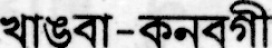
খাঙবা-কনবগী
